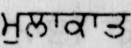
ਮੁਲਾਕਾਤ
